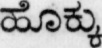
ಹೊಕ್ಕು
